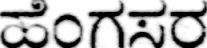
ಹೆಂಗಸರ
